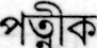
পত্নীক
